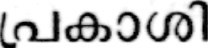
പ്രകാശി
